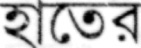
হাতের
